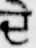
ਦੇ
